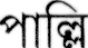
পাল্লি
